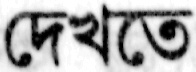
দেখতে
